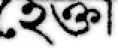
হেক্তা
